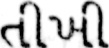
તીખી
